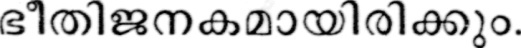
ഭീതിജനകമായിരിക്കും.
